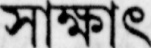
সাক্ষাৎ
